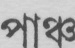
পাঞ্চ
